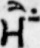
ਮੈਂ
